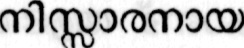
നിസ്സാരനായ
